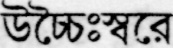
উচ্চৈঃস্বরে
